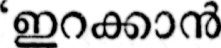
'ഇറക്കാന്‍
